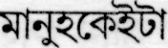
মানুহকেইটা
